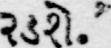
રડશે.'
